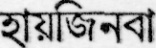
হায়জিনবা
